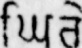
ਘਿਰੇ
